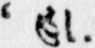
'હા.
